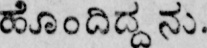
ಹೊಂದಿದ್ದನು.
